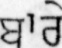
ਬਾਰੇ
